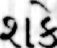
શકે
